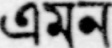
এমন
